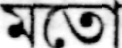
মতো
